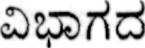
ವಿಭಾಗದ
